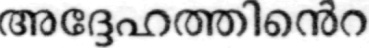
അദ്ദേഹത്തിന്റെ
